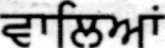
ਵਾਲਿਆਂ
